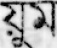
য়ুম
